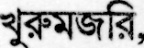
খুরুমজরি,
